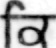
ਕਿ
